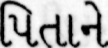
પિતાને
